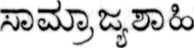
ಸಾಮ್ರಾಜ್ಯಶಾಹಿ
